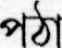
পঠা
